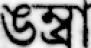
ঙম্ব্রা
